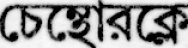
চেন্থোরক্লে
